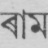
ৰাম
